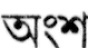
অংশ
